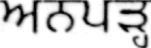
ਅਨਪੜ੍ਹ
